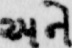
અને
